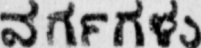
ವರ್ಗಗಳು
